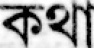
কথা
